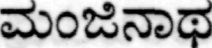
ಮಂಜಿನಾಥ
